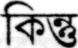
কিন্তু
